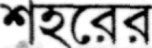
শহরের
